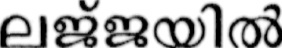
ലജ്ജയില്‍
